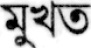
মুখত
